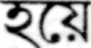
হয়ে
